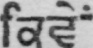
ਕਿਵੇਂ
